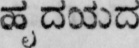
ಹೃದಯದ
